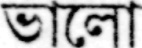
ভালো
